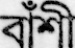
বাঁশী
